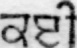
ਕਈ
